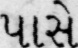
પાસે
